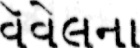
વૅવેલના
